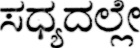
ಸಧ್ಯದಲ್ಲೇ
